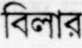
বিলার
